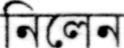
নিলেন
